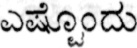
ಎಷ್ಟೊಂದು
